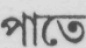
পাতে
